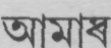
আমাৰ
